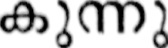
കുന്നു
